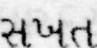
સખત
